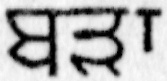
ਬੜਾ
